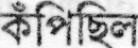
কঁপিছিল
